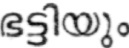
ഭട്ടിയും
